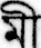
মী
